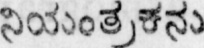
ನಿಯಂತ್ರಕನು
